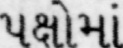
પક્ષોમાં
